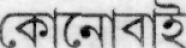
কোনোবাই
